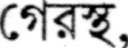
গেরস্থ,
